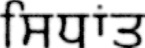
ਸਿਧਾਂਤ
